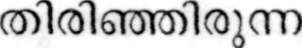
തിരിഞ്ഞിരുന്ന
